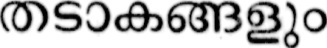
തടാകങ്ങളും
